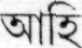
আহি
